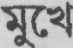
মুখে
